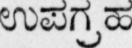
ಉಪಗ್ರಹ
